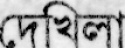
দেখিলা
